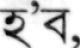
হ'ব,
